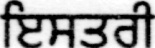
ਇਸਤਰੀ
